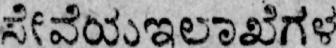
ಸೇವೆಯಇಲಾಖೆಗಳ
